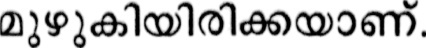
മുഴുകിയിരിക്കയാണ്.
